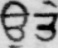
ਉਤੇ
